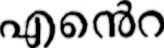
എന്റെ
